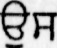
ਉਸ
